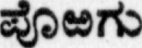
ಪೊಱಗು
